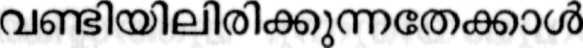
വണ്ടിയിലിരിക്കുന്നതേക്കാള്‍
